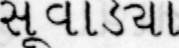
સૂવાડ્યા
